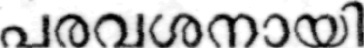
പരവശനായി
